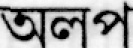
অলপ
